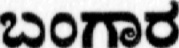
ಬಂಗಾರ
